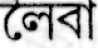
লৈবা
